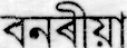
বনৰীয়া
